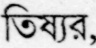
তিষ্যর,
